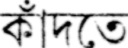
কাঁদতে
